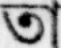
তা
